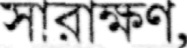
সারাক্ষণ,
